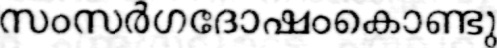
സംസര്‍ഗദോഷംകൊണ്ടു
